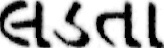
લડતા
